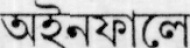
অইনফালে
